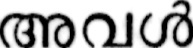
അവള്‍
